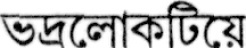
ভদ্রলোকটিয়ে
